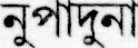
নুপাদুনা
